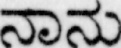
ನಾನು
